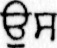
ਉਸ
